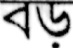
বড়
